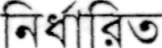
নির্ধারিত
